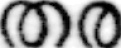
തര
